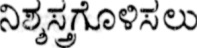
ನಿಶ್ಶಸ್ತ್ರಗೊಳಿಸಲು
